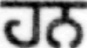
ਹਨ
